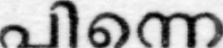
പിന്നെ
